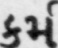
કર્મ
